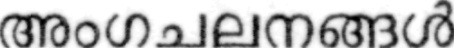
അംഗചലനങ്ങള്‍
